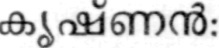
കൃഷ്ണന്‍:
